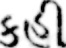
કહી
